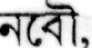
নবৌ,
